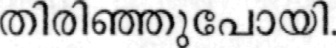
തിരിഞ്ഞുപോയി.
